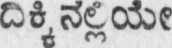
ದಿಕ್ಕಿನಲ್ಲಿಯೇ
